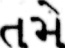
તમે
